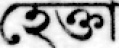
হেক্তা
